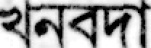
খনবদা
